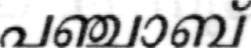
പഞ്ചാബ്
